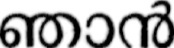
ഞാന്‍
